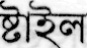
ষ্টাইল
